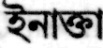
ইনাক্তা
